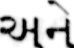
અને
